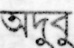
অদুবু
